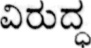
ವಿರುದ್ದ
